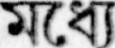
মধ্যে
